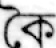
কৈ
